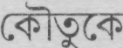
কৌতুকে
